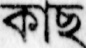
কাছ
